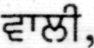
ਵਾਲੀ,
